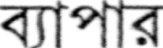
ব্যাপার
